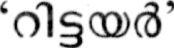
‘റിട്ടയര്‍’
